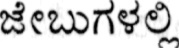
ಜೇಬುಗಳಲ್ಲಿ
